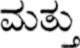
ಮತ್ತು
